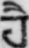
ਹੈ
